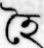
হৈ
